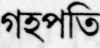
গহপতি
